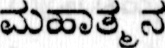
ಮಹಾತ್ಮನ
